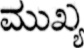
ಮುಖ್ಯ
